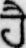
ਹੈ
